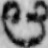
ಆ
